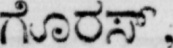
ಗೊರಸ್,
